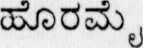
ಹೊರಮೈ
